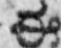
ಈ
